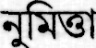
নুমিত্তা
